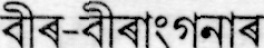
বীৰ-বীৰাংগনাৰ
